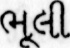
ભૂલી
